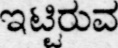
ಇಟ್ಟಿರುವ
